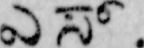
ಎಸ್.
